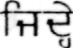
ਜਿਦ੍ਹੇ
